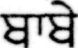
ਬਾਬੇ
